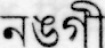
নঙগী
